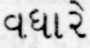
વધારે
